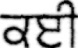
ਕਈ
